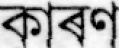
কাৰণ
